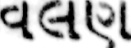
વલણ
